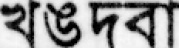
খঙদবা
